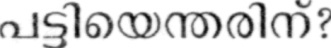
പട്ടിയെന്തരിന്?
